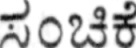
ಸಂಚಿಕೆ
